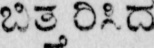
ಬಿತ್ತರಿಸಿದ
